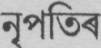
নৃপতিৰ
